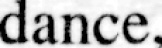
dance,
